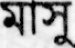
মাসু
